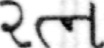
રત્ન
